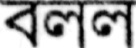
বলল
